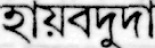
হায়বদুদা
